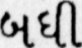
બધી
